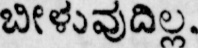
ಬೀಳುವುದಿಲ್ಲ.
